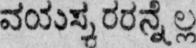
ವಯಸ್ಕರರನ್ನೆಲ್ಲ
